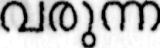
വരുന്ന
